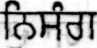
ਨਿਸੰਗ
